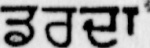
ਡਰਦਾ
